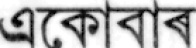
একোবাৰ
